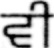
ਵੀ
